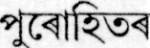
পুৰোহিতৰ
